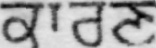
ਕਾਰਣ
